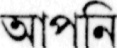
আপনি
